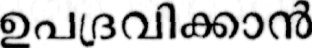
ഉപദ്രവിക്കാന്‍
